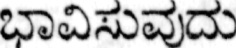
ಭಾವಿಸುವುದು
